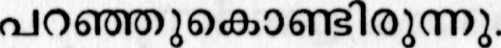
പറഞ്ഞുകൊണ്ടിരുന്നു.
